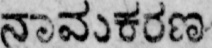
ನಾಮಕರಣ
